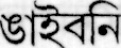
ঙাইবনি
